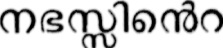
നഭസ്സിന്റെ
